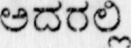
ಅದರಲ್ಲಿ
